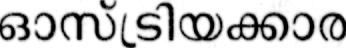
ഓസ്ട്രിയക്കാര
